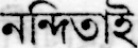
নন্দিতাই
